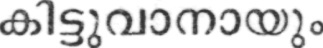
കിട്ടുവാനായും
